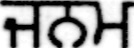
ਜਨਮ
